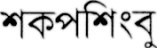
শকপশিংবু
